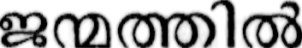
ജന്മത്തില്‍
